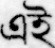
এই
